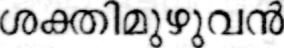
ശക്തിമുഴുവന്‍
